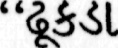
"ઢૂકડા
